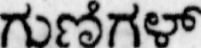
ಗುಣಿಗಳ್
